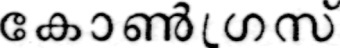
കോണ്‍ഗ്രസ്
